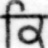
ਕਿ
